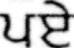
ਪਏ
